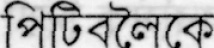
পিটিবলৈকে
